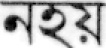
নহয়
